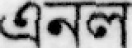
এনল
